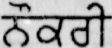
ਨੌਕਰੀ
